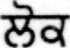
ਲੋਕ
